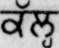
ਕੱਲ੍ਹ
